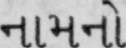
નામનો
